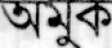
অমুক
